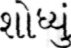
શોધ્યું
